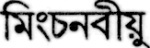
মিংচনবীয়ু
